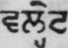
ਵਲ੍ਹੇਟ
